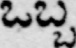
ಒಬ್ಬ
